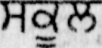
ਸਕੂਲ
